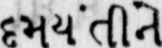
દમયંતીને
